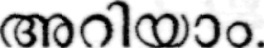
അറിയാം.
